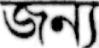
জন্য
